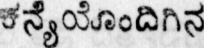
ಕನ್ಯೆಯೊಂದಿಗಿನ
